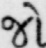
જો
